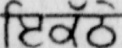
ਇਕੱਠੇ
